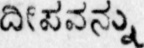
ದೀಪವನ್ನು
